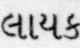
લાયક
